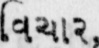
વિચાર,
